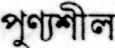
পুণ্যশীল
